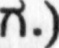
ಗ.)
